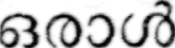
ഒരാള്‍
